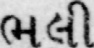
ભલી
